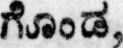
ಗೊಂಡ,
